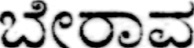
ಬೇರಾವ
